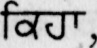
ਕਿਹਾ,
